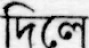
দিলে
